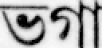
ভগা
